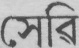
সেৱি
